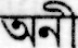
অনী
